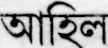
আহিল
